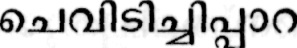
ചെവിടിച്ചിപ്പാറ
